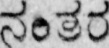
ನಂತರ
